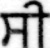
ਸੀ
